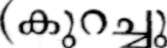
(കുറച്ചു
